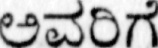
ಅವರಿಗೆ
